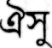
ঐসু
